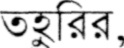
তহুরির,
